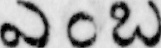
ಎಂಬ
